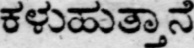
ಕಳುಹುತ್ತಾನೆ
